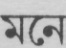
মনে
